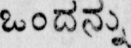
ಒಂದನ್ನು
